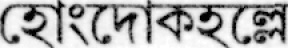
হোংদোকহল্লে
